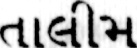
તાલીમ
